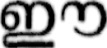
ഈ
